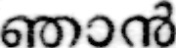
ഞാന്‍
